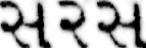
સરસ
